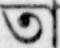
তা
